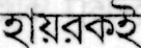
হায়রকই
